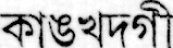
কাঙখদগী
